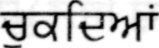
ਚੁਕਦਿਆਂ
